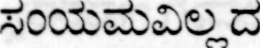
ಸಂಯಮವಿಲ್ಲದ
